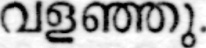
വളഞ്ഞു.
